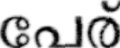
പേര്
